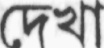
দেখা
